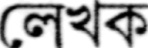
লেখক
